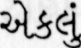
એકલું
